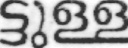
ട്ടുള്ള
